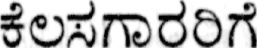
ಕೆಲಸಗಾರರಿಗೆ
